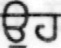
ਉਹ
